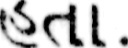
હતા.
